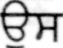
ਉਸ
